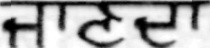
ਜਾਣਦਾ
